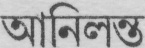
আনিলন্ত
